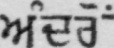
ਅੰਦਰੋਂ
